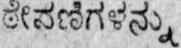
ಠೇವಣಿಗಳನ್ನು
